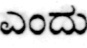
ಎಂದು
